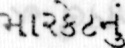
મારકેટનું
